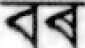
বৰ
